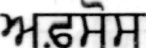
ਅਫ਼ਸੋਸ
